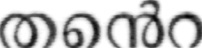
തന്റെ
